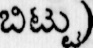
ಬಿಟ್ಟು)
